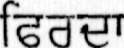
ਫਿਰਦਾ
